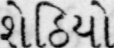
શેઠિયો
